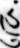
હું
